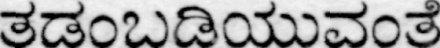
ತಡಂಬಡಿಯುವಂತೆ
